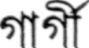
গার্গী
